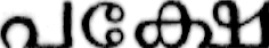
പക്ഷേ
